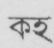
কহ
